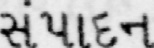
સંપાદન
